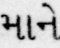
માને
